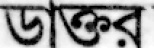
ডাক্তর
